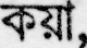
কয়া,
